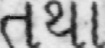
તથા
